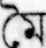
মৈ
